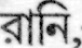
রানি,
